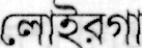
লোইরগা
